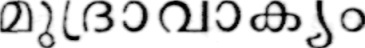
മുദ്രാവാക്യം
